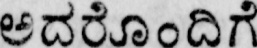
ಅದರೊಂದಿಗೆ
